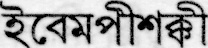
ইবেমপীশক্কী
